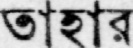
তাহার
